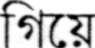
গিয়ে
